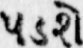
પડશે?
